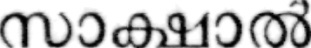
സാക്ഷാല്‍
